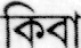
কিবা
